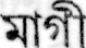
মাগী
